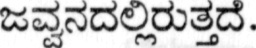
ಜವ್ವನದಲ್ಲಿರುತ್ತದೆ.
